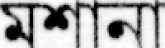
মশানা
